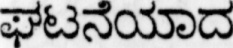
ಘಟನೆಯಾದ
